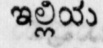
ಇಲ್ಲಿಯ
